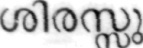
ശിരസ്സു
